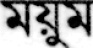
ময়ুম
